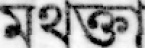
মথক্তা
